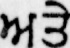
ਅਤੇ
